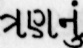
ત્રણનું
